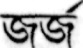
জর্জ
